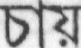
চায়
